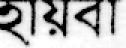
হায়বা
